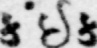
કંઈક
